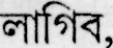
লাগিব,
